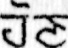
ਹੋਣ
